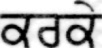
ਕਰਕੇ
